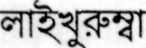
লাইখুরুম্বা
